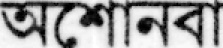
অশোনবা
